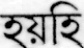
হয়হি
